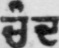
ਚੰਦ
